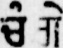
ਚੰਗੇ
